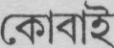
কোবাই
